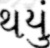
થયું
